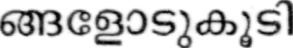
ങ്ങളോടുകൂടി
